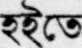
হইতে
